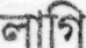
লাগি
